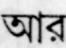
আর
